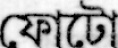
ফোটো
